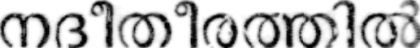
നദീതീരത്തില്‍
